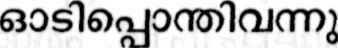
ഓടിപ്പൊന്തിവന്നു
